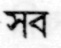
সব
